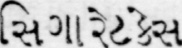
સિગારેટકેસ
